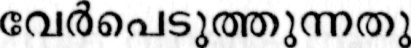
വേര്‍പെടുത്തുന്നതു
